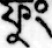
ফুং
